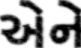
એને
